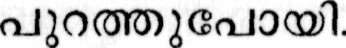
പുറത്തുപോയി.
